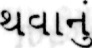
થવાનું
